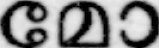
മോ
